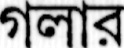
গলার
